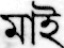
মাই
